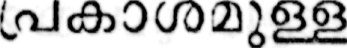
പ്രകാശമുള്ള
